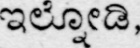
ಇಲ್ನೋಡಿ,
